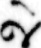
જે
